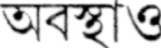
অবস্থাও
